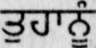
ਤੁਹਾਨੂੰ
